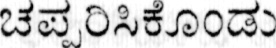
ಚಪ್ಪರಿಸಿಕೊಂಡು
